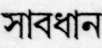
সাবধান
